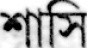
শাসি
